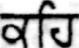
ਕਹਿ
